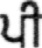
ਪੀ
